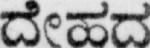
ದೇಹದ
